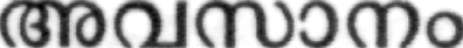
അവസാനം
